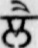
ਲੈ
